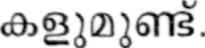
കളുമുണ്ട്.
